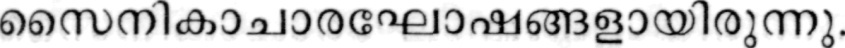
സൈനികാചാരഘോഷങ്ങളായിരുന്നു.
